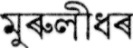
মুৰুলীধৰ
